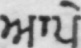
ਆਪੇ
